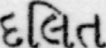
દલિત
